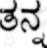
ತನ್ನ
